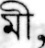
মী,
